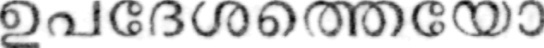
ഉപദേശത്തെയോ
